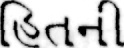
હિતની
